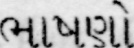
ભાષણો
